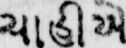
ચાહીએ
